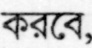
করবে,
